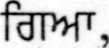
ਗਿਆ,
